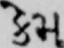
કેમ
